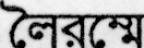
লৈরম্মে
